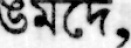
ঙমদে,
